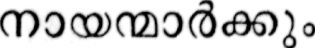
നായന്മാര്‍ക്കും
